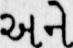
અને
